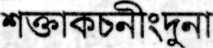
শক্তাকচনীংদুনা
